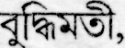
বুদ্ধিমতী,
